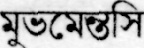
মুভমেন্তসি
